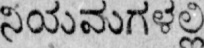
ನಿಯಮಗಳಲ್ಲಿ
